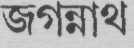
জগন্নাথ
